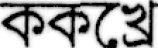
ককখ্রে
